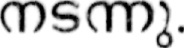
നടന്നു.
